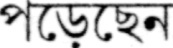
পড়েছেন
